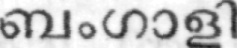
ബംഗാളി
